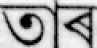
তাৰ
